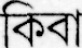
কিবা
